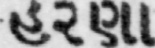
હરણા
